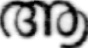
ആ
